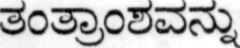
ತಂತ್ರಾಂಶವನ್ನು
